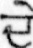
ਦੇ
